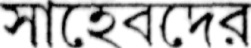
সাহেবদের
